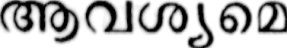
ആവശ്യമെ
